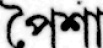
পৈশা
